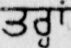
ਤਰ੍ਹਾਂ
